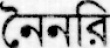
নৈনরি
